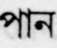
পান
